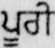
ਪੂਰੀ
